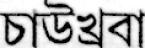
চাউখ্রবা
